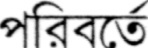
পরিবর্তে
